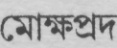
মোক্ষপ্ৰদ
